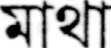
মাথা
